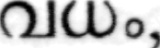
വധം,
